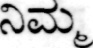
ನಿಮ್ಮ
